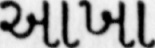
આખા
